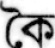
কৈ
